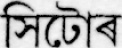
সিটোৰ
